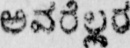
ಅವರೆಲ್ಲರ
